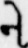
ને
